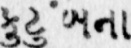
કુટુંબના
